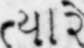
ત્યારે
